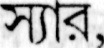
স্যার,
